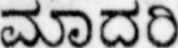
ಮಾದರಿ
